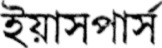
ইয়াসপার্স
